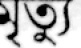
মৃত্যু
